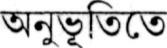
অনুভূতিতে
